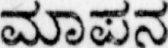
ಮಾಪನ
